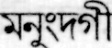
মনুংদগী
